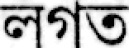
লগত
